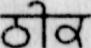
ਠੀਕ
